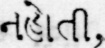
નહોતી,
